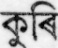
কুৰি
